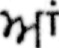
ਆਂ
